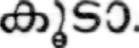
കൂടാ.
